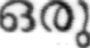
ഒരു
